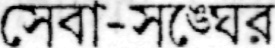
সেবা-সঙ্ঘের
